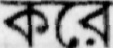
করে
